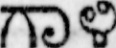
ಗಾಳಿ
